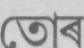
তোৰ
